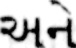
અને
